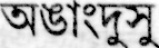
অঙাংদুসু
